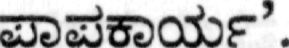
ಪಾಪಕಾರ್ಯ’.
